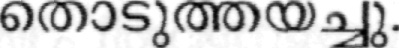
തൊടുത്തയച്ചു.
